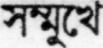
সম্মুখে
